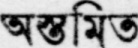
অস্তমিত
